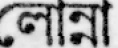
লোন্না
